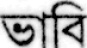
ভাবি
